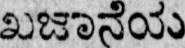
ಖಜಾನೆಯ
